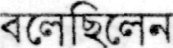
বলেছিলেন
